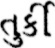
તુર્કી
